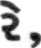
રે,
